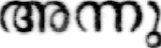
അന്നു
